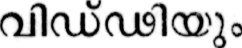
വിഡ്ഢിയും
